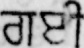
ਗਈ
